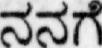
ನನಗೆ
